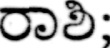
ರಾಶಿ;
